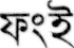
ফংই
